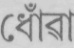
ধোঁৱা
